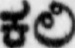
ಕಲಿ
